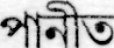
পানীত
